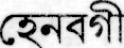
হেনবগী
